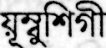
য়ূম্বুশিগী
